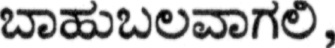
ಬಾಹುಬಲವಾಗಲಿ,
